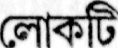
লোকটি
